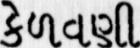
કેળવણી
